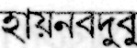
হায়নবদুবু
